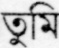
তুমি
